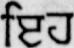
ਇਹ
